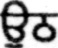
ਉਠ
